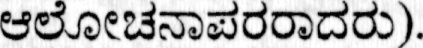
ಆಲೋಚನಾಪರರಾದರು).
